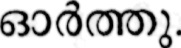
ഓര്‍ത്തു.
